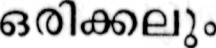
ഒരിക്കലും
